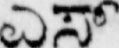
ಎಸ್
